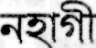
নহাগী
